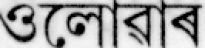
ওলোৱাৰ
